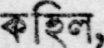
কহিল,
